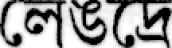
লেঙদ্রে
